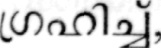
ഗ്രഹിച്ച്,
